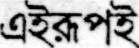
এইরূপই
